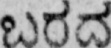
ಬರದ
